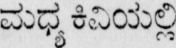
ಮಧ್ಯಕಿವಿಯಲ್ಲಿ
